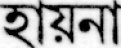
হায়না
